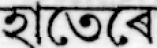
হাতেৰে
